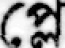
প্লে
